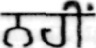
ਨਹੀਂ
